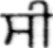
ਸੀ
